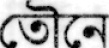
তৌনে
